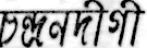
চন্দ্রনদীগী
